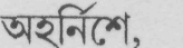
অহৰ্নিশে,
